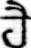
ਹੈ
